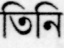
তিনি
